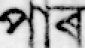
পাৰ
